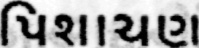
પિશાચણ
